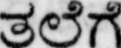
ತಲೆಗೆ
